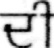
ਦੀ
